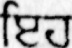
ਇਹ
